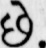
છે.
